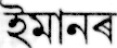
ইমানৰ
